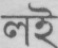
লই
